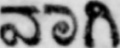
ವಾಗಿ
